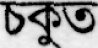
চকুত
